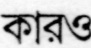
কারও
